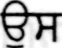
ਉਸ
